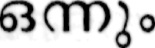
ഒന്നും
